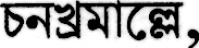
চনখ্রমাল্লে,
